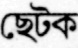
ছেটক
